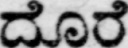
ದೊರೆ
